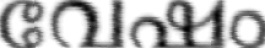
വേഷം
